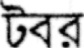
টবর
